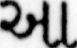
આ
